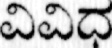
ವಿವಿಧ
